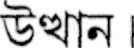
উত্থান।
